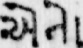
એનો
